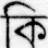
কি
